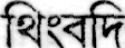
থিংবদি
